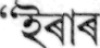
"ইৰাৰ
